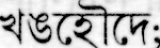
খঙহৌদে;
